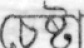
চেষ্টা
